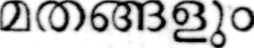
മതങ്ങളും
